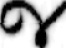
જ
